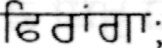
ਫਿਰਾਂਗਾ;
